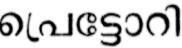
പ്രെട്ടോറി
